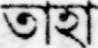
তাহা
